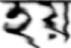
হয়
